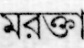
মরক্তা
